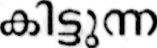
കിട്ടുന്ന
